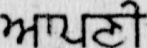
ਆਪਣੀ
